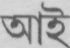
আই
